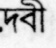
দেবী
